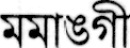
মমাঙগী
